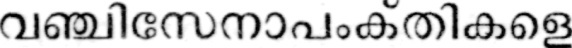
വഞ്ചിസേനാപംക്തികളെ
